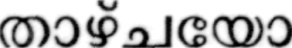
താഴ്ചയോ
